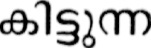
കിട്ടുന്ന
